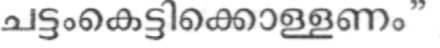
ചട്ടംകെട്ടിക്കൊള്ളണം”
